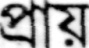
প্রায়
